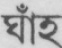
ঘাঁহ
